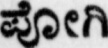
ಪೋಗಿ
